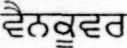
ਵੈਨਕੂਵਰ
